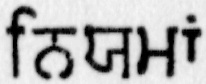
ਨਿਯਮਾਂ
